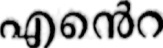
എന്റെ
